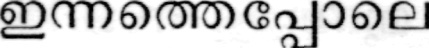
ഇന്നത്തെപ്പോലെ
